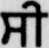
ਸੀ
